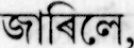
জাৰিলে,
